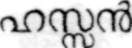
ഹസ്സന്‍
